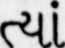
ત્યાં
